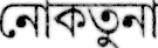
নোকতুনা
